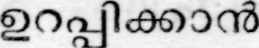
ഉറപ്പിക്കാന്‍
